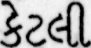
કેટલી
